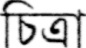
চিত্রা
